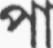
পা
